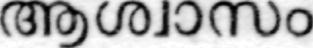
ആശ്വാസം
